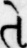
તે
